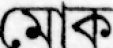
মোক
